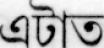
এটাত
